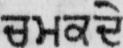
ਚਮਕਦੇ
